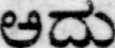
ಅದು
